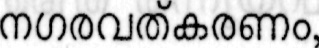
നഗരവത്കരണം,
